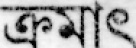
ক্রমাৎ
